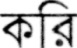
করি
